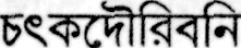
চৎকদৌরিবনি
